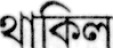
থাকিল
